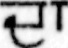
ਦਾ
